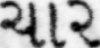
ચાર
